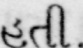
હતી.
